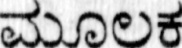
ಮೂಲಕ
